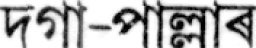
দগা-পাল্লাৰ
